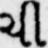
ચીં
